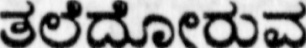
ತಲೆದೋರುವ
